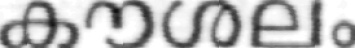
കൌശലം
